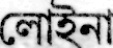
লোইনা
